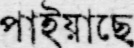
পাইয়াছে
